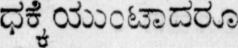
ಧಕ್ಕೆಯುಂಟಾದರೂ
